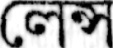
লেন্স
